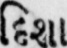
દિશા
